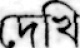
দেখি
